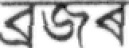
ব্রজৰ
